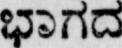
ಭಾಗದ
